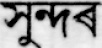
সুন্দৰ
